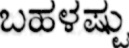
ಬಹಳಷ್ಟು
